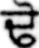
ਢੋ
